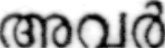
അവര്‍
